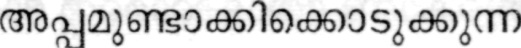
അപ്പമുണ്ടാക്കിക്കൊടുക്കുന്ന
